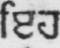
ਇਹ
